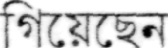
গিয়েছেন
